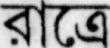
রাত্রে
